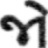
જો
